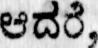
ಆದರೆ,
